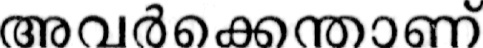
അവര്‍ക്കെന്താണ്
